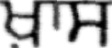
ਖ਼ਾਸ
